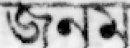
জনম
